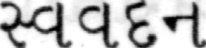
સ્વવદન
